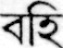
বহি
